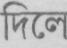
দিলে
